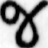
જ
